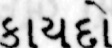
કાયદો
